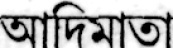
আদিমাতা
